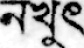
নখুৎ
